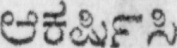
ಆಕರ್ಷಿಸಿ
